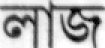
লাজ
